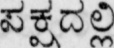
ಪಕ್ಷದಲ್ಲಿ
